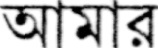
আমার
